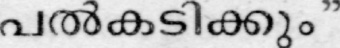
പല്‍കടിക്കും.”
